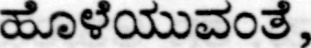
ಹೊಳೆಯುವಂತೆ,
